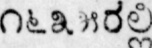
೧೬೩೫ರಲ್ಲಿ
